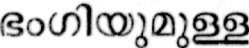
ഭംഗിയുമുള്ള
